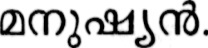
മനുഷ്യന്‍.
